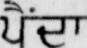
ਪੈਂਦਾ
